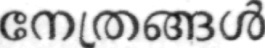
നേത്രങ്ങള്‍
